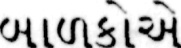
બાળકોએ
